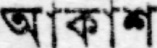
আকাশ
